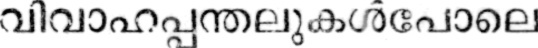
വിവാഹപ്പന്തലുകള്‍പോലെ
